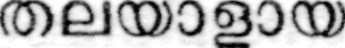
തലയാളായ
